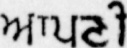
ਆਪਣੀ
